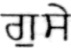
ਗੁਸੇ
